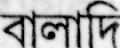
বালাদি
